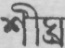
শীঘ্ৰ
